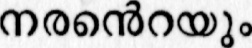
നരന്റെയും
